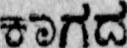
ಕಾಗದ
